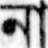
না
